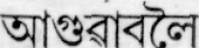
আগুৱাবলৈ
